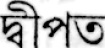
দ্বীপত
